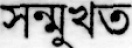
সন্মুখত
